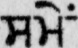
ਸਮੇਂ
